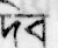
দিব
